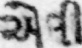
એવી
